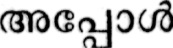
അപ്പോള്‍
